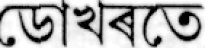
ডোখৰতে
